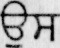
ਉਸ
